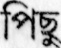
পিছু
